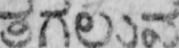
ತಗಲುವ
